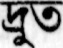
দ্রুত
